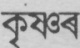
কৃষ্ণৰ
